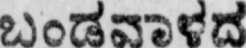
ಬಂಡವಾಳದ
